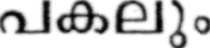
പകലും
